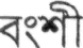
বংশী
